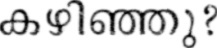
കഴിഞ്ഞു?
